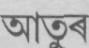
আতুৰ
